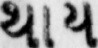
થાય
